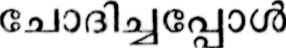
ചോദിച്ചപ്പോള്‍
